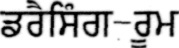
ਡਰੈਸਿੰਗ-ਰੂਮ
